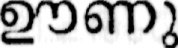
ഊണു
